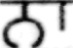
ਨਾ
